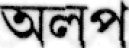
অলপ
